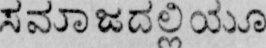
ಸಮಾಜದಲ್ಲಿಯೂ
